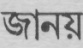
জানয়
